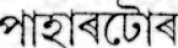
পাহাৰটোৰ
